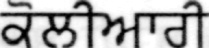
ਕੋਲੀਆਰੀ
